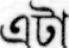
এটা
